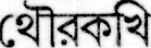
থৌরকখি
